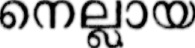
നെല്ലായ
